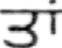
ਤਾਂ
